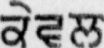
ਕੇਵਲ
